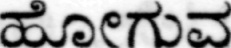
ಹೋಗುವ
